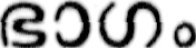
ഭാഗം
